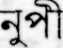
নুপী
